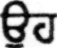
ਉਹ
